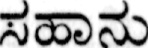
ಸಹಾನು
